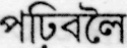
পঢ়িবলৈ
